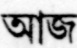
আজ
